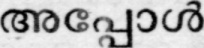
അപ്പോള്‍
